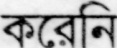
করেনি
